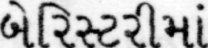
બેરિસ્ટરીમાં
